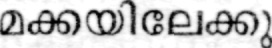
മക്കയിലേക്കു
